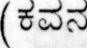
(ಕವನ
